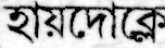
হায়দোক্লে
